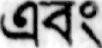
এবং
